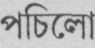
পচিলো
